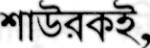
শাউরকই,
